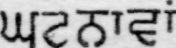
ਘਟਨਾਵਾਂ
